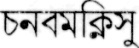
চনবমক্নিসু
